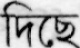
দিছে
